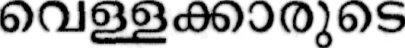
വെള്ളക്കാരുടെ
